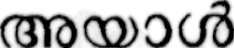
അയാള്‍
